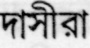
দাসীরা
